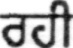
ਰਹੀ
